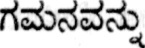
ಗಮನವನ್ನು
